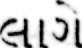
લાગે
